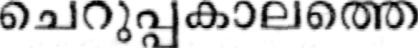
ചെറുപ്പകാലത്തെ
